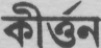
কীৰ্ত্তন
